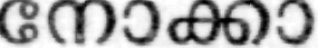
നോക്കാ
